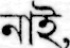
নাই,
